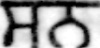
ਸਨ
